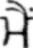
ਮੈਂ
